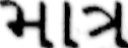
માત્ર
